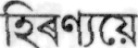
হিৰণ্যয়ে
